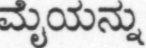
ಮೈಯನ್ನು
